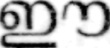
ഈ
